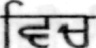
ਵਿਚ
